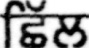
ਛਿੱਲ
